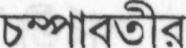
চম্পাবতীর
